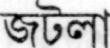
জটলা
